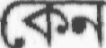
কেন
